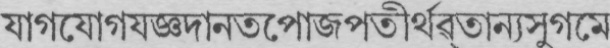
যাগযোগযজ্ঞদানতপোজপতীৰ্থৱ্‌তান্যসুগমে
